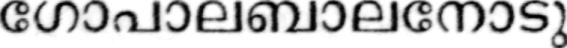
ഗോപാലബാലനോടു
